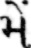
મેં
